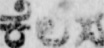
ಕೆಲಸ
